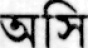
অসি
